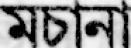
মচানা
